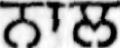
ਨਾਲ
